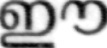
ഈ
